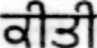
ਕੀਤੀ
